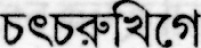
চৎচরুখিগে
